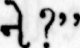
ને?"
